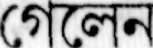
গেলেন
